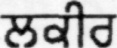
ਲਕੀਰ
